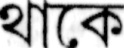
থাকে
